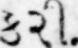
કરી.
